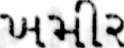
ખમીર
